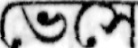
ভেসে
